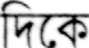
দিকে
